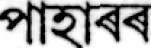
পাহাৰৰ
